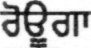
ਰੋਊਗਾ
